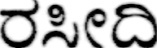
ರಸೀದಿ
